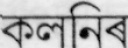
কলনিৰ
